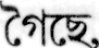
গৈছে,
